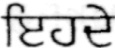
ਇਹਦੇ
